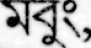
মবুং,
